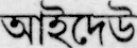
আইদেউ
